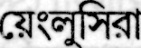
য়েংলুসিরা
